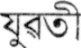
যুৱতী
